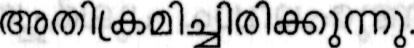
അതിക്രമിച്ചിരിക്കുന്നു.
